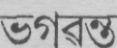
ভগৱন্ত
